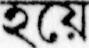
হয়ে
